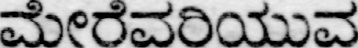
ಮೇರೆವರಿಯುವ
